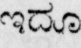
ಇದೂ
